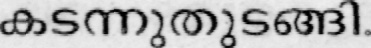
കടന്നുതുടങ്ങി.
